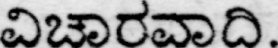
ವಿಚಾರವಾದಿ.
